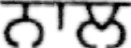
ਨਾਲ
